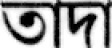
তাদা
